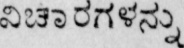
ವಿಚಾರಗಳನ್ನು
